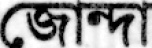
জোন্দা
